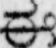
ಈ
